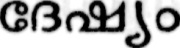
ദേഷ്യം
